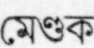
মেণ্ডক
